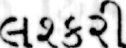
લશ્કરી
